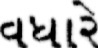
વધારે
